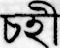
চহী
